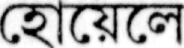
হোয়েলে
